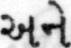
અને
